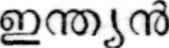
ഇന്ത്യന്‍
